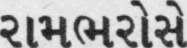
રામભરોસે
